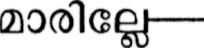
മാരില്ലേ-
